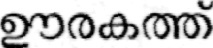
ഊരകത്ത്
